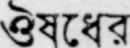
ঔষধের
